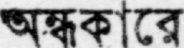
অন্ধকারে
